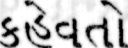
કહેવતો
